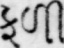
ફળી
